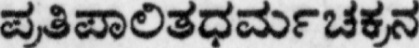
ಪ್ರತಿಪಾಲಿತಧರ್ಮಚಕ್ರನ
